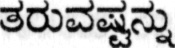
ತರುವಷ್ಟನ್ನು
